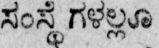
ಸಂಸ್ಥೆಗಳಲ್ಲೂ
